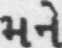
મને
